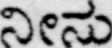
ನೀನು
